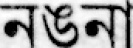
নঙনা
